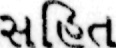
સહિત
